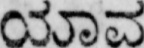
ಯಾವ
